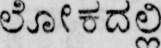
ಲೋಕದಲ್ಲಿ
